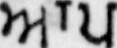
ਆਪ
